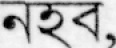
নহব,
